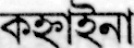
কহ্নাইনা
